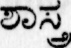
ಶಾಸ್ತ್ರ
